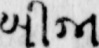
બીજા
